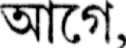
আগে,
